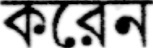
করেন
